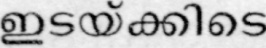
ഇടയ്ക്കിടെ
